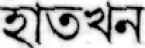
হাতখন
